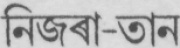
নিজৰা-তান
